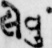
લેવું
